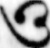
ও
